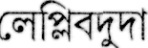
লেপ্লিবদুদা
